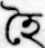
হৈ
